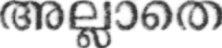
അല്ലാതെ
